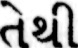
તેથી
